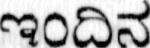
ಇಂದಿನ
